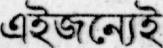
এইজন্যেই
